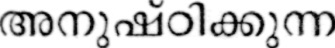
അനുഷ്ഠിക്കുന്ന
